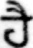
ਹੈ
